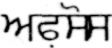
ਅਫ਼ਸੋਸ
